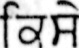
ਕਿਸੇ
